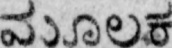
ಮೂಲಕ
